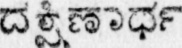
ದಕ್ಷಿಣಾರ್ಧ
